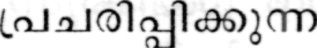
പ്രചരിപ്പിക്കുന്ന
